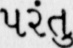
પરંતુ
